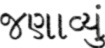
જણાવ્યું
